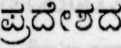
ಪ್ರದೇಶದ
